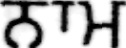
ਨਾਮ
